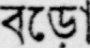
বড়ো
